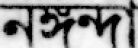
নঙ্গন্দা
